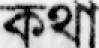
কথা
